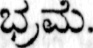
ಭ್ರಮೆ.
